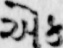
એક
